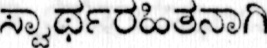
ಸ್ವಾರ್ಥರಹಿತನಾಗಿ
